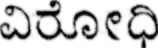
ವಿರೋಧಿ
